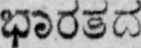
ಭಾರತದ
